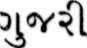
ગુજરી
